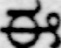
ಈ
